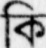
কি
